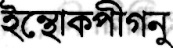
ইন্থোকপীগনু
